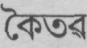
কৈতৱ
